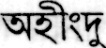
অহীংদু
